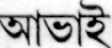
আভাই
